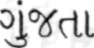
ગુંજતા
